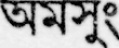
অমসুং
